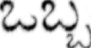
ಒಬ್ಬ
